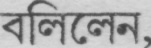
বলিলেন,
